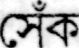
সেঁক
